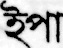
ইপা
